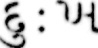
દુઃખ
